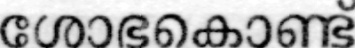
ശോഭകൊണ്ട്
